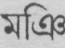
মঞি
